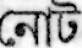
নোট
